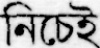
নিচেই
